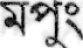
মপুং
